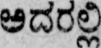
ಅದರಲ್ಲಿ
